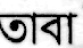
তাবা
